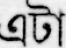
এটা
